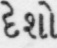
દેશો
